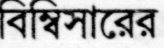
বিম্বিসারের
